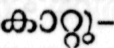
കാറ്റു-
